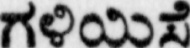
ಗಳಿಯಿಸೆ
